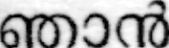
ഞാന്‍
